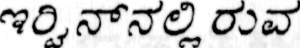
ಇರ್‍ವಿನ್‌ನಲ್ಲಿರುವ
